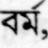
বর্ম,
